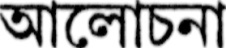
আলোচনা
